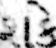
શકે
